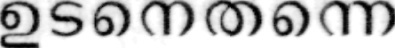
ഉടനെതന്നെ
